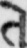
,તે
